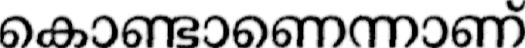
കൊണ്ടാണെന്നാണ്
